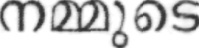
നമ്മുടെ
